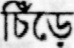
চিঁড়ে
